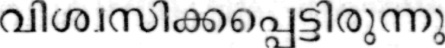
വിശ്വസിക്കപ്പെട്ടിരുന്നു
